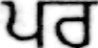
ਪਰ
